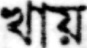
খায়
